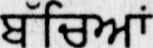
ਬੱਚਿਆਂ
